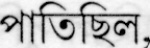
পাতিছিল,
